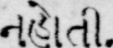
નહોતી.
